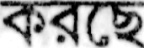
করছে
